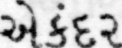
એકંદર
